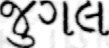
જુગલ
